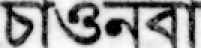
চাওনবা
